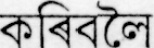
কৰিবলৈ
